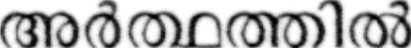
അര്‍ത്ഥത്തില്‍
